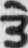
ਤੇ
